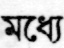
মধ্যে
